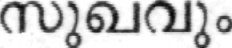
സുഖവും
